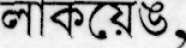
লাকয়েঙ,
